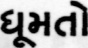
ધૂમતો
